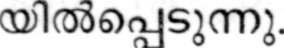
യില്‍പ്പെടുന്നു.
